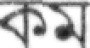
কম
